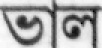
ভাল
